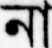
না
